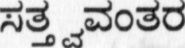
ಸತ್ತ್ವವಂತರ
